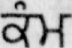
ਕੰਮ
